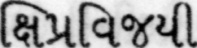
ક્ષિપ્રવિજયી
